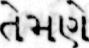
તેમણે
